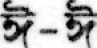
ঈ-ঈ
